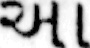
આ
